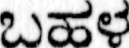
ಬಹಳ
